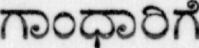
ಗಾಂಧಾರಿಗೆ
